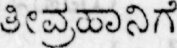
ತೀವ್ರಹಾನಿಗೆ
